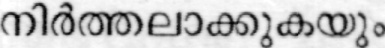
നിര്‍ത്തലാക്കുകയും
